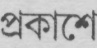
প্রকাশে
